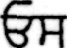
ਓਸ
